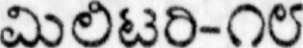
ಮಿಲಿಟರಿ-೧೮
